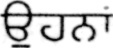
ਉਹਨਾਂ
